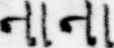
નાના
